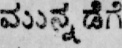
ಮುನ್ನಡೆಗೆ
